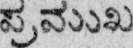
ಪ್ರಮುಖ
